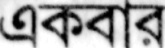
একবার
